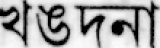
খঙদনা
